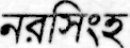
নরসিংহ
